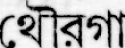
থৌরগা
